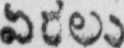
ಏರಲು
